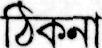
ঠিকনা
